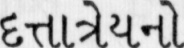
દત્તાત્રેયનો
